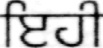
ਇਹੀ
